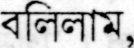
বলিলাম,
